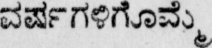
ವರ್ಷಗಳಿಗೊಮ್ಮೆ
